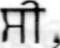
ਸੀ,
